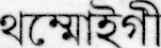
থম্মোইগী
